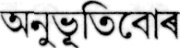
অনুভূতিবোৰ
